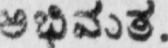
ಅಭಿಮತ.
